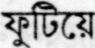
ফুটিয়ে
